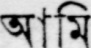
আমি
